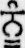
ਨੂੰ
